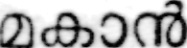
മകാന്‍
